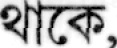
থাকে,
